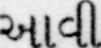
આવી
